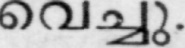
വെച്ചു.
